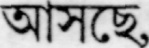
আসছে,
